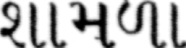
શામળા
